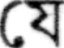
যে
